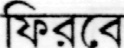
ফিরবে
